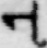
ન
